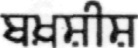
ਬਖ਼ਸ਼ੀਸ਼
